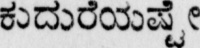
ಕುದುರೆಯಷ್ಟೇ
